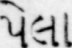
પેલા
